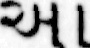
આ
